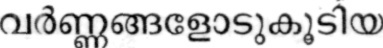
വര്‍ണ്ണങ്ങളോടുകൂടിയ
